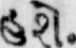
હશે.
